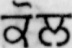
ਕੋਲ
